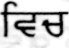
ਵਿਚ
